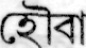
হৌবা
